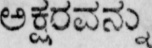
ಅಕ್ಷರವನ್ನು
